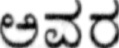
ಅವರ
